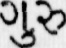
ગુરુ
